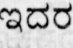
ಇದರ
